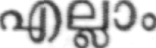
എല്ലാം
